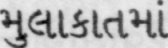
મુલાકાતમાં
